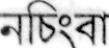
নচিংবা
